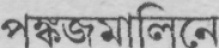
পঙ্কজমালিনে
